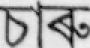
চাৰু
